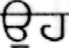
ਉਹ
